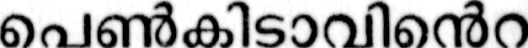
പെണ്‍കിടാവിന്റെ
